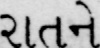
રાતને
